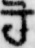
ਹੋ
